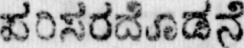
ಪರಿಸರದೊಡನೆ
